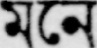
মনে
